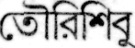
তৌরিশিবু
